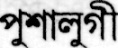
পুশালুগী
